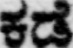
ಕಡೆ
